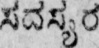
ಸದಸ್ಯರ
